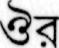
ঔর
